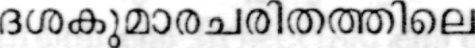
ദശകുമാരചരിതത്തിലെ
